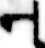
ન
